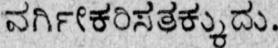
ವರ್ಗೀಕರಿಸತಕ್ಕದು
